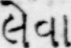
લેવા
